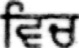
ਵਿਚ
